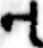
ન
